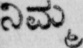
ನಿಮ್ಮ
